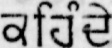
ਕਹਿੰਦੇ
